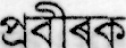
প্রবীৰক
